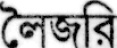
লৈজরি
